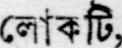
লোকটি,
